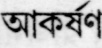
আকর্ষণ
